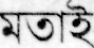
মতাই
